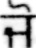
ਜੋ
